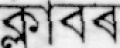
ক্লাবৰ
